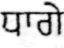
ਧਾਗੇ
